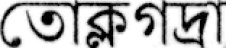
তোক্লগদ্রা
